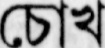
চোখ
